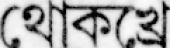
থোকখ্রে
